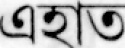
এহাত
